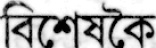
বিশেষকৈ
